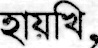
হায়খি,
